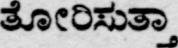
ತೋರಿಸುತ್ತಾ
